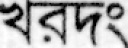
খরদং
